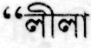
“লীলা
